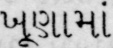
ખૂણામાં
